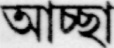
আচ্ছা
